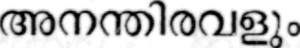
അനന്തിരവളും
